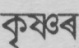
কৃষ্ণৰ
